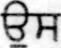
ਉਸ
